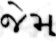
જેમ
